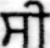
ਸੀ
